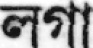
লগা
